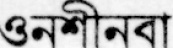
ওনশীনবা
